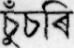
চুঁচৰি
